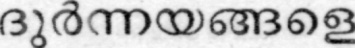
ദുര്‍ന്നയങ്ങളെ
